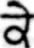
ਕੇ
